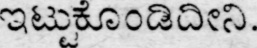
ಇಟ್ಟುಕೊಂಡಿದೀನಿ.
